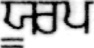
ਯੂਰਪ
